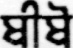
ਬੀਬੋ
